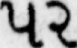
પર
